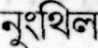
নুংথিল
